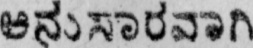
ಅನುಸಾರವಾಗಿ
